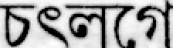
চৎলগে
